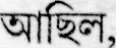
আছিল,
